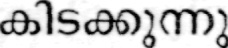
കിടക്കുന്നു
